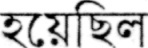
হয়েছিল
